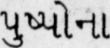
પુષ્પોના
